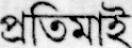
প্রতিমাই
